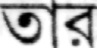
তার
